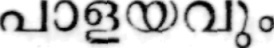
പാളയവും
